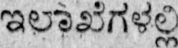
ಇಲಾಖೆಗಳಲ್ಲಿ
